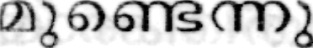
മുണ്ടെന്നു
